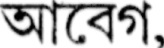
আবেগ,
